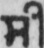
ਸੀ
